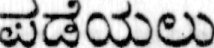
ಪಡೆಯಲು
